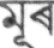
মূৰ
